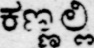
ಕಣ್ಣಲ್ಲಿ
